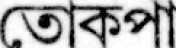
তোকপা
